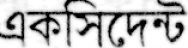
একসিদেন্ট
